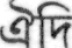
ঐদি
